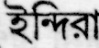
ইন্দিরা
